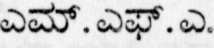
ಎಮ್.ಎಫ್.ಎ.
